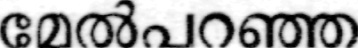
മേല്‍പറഞ്ഞ
